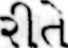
રીતે
